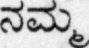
ನಮ್ಮ
